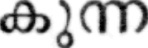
കുന്ന
